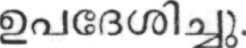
ഉപദേശിച്ചു.
